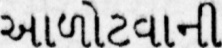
આળોટવાની
